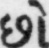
છો
